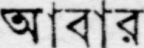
আবার
